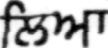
ਲਿਆ
